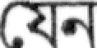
যেন
